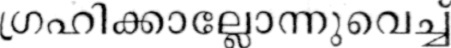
ഗ്രഹിക്കാല്ലോന്നുവെച്ച്
